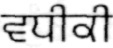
ਵਧੀਕੀ
